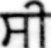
ਸੀ
